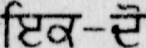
ਇਕ-ਦੋ
